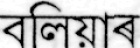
বলিয়াৰ
